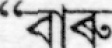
"বাৰু
